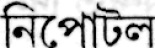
নিপোটল
